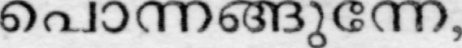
പൊന്നങ്ങുന്നേ,
